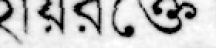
হায়রক্তে
